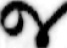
જ
